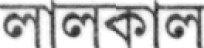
লালকাল
